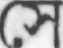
সে
